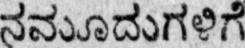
ನಮೂದುಗಳಿಗೆ
